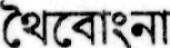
থৈবোংনা
